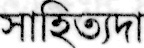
সাহিত্যদা
